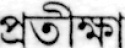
প্রতীক্ষা
